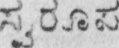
ಸ್ವರೂಪ
